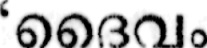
‘ദൈവം
